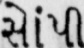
સોંપી
